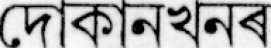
দোকানখনৰ
